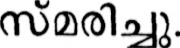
സ്മരിച്ചു.
